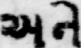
અને
